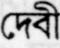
দেবী
